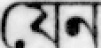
যেন
